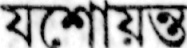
যশোয়ন্ত
